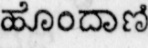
ಹೊಂದಾಣಿ
